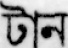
টান
